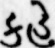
કહે
